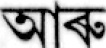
আৰু
